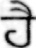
ਹੈ
